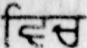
ਵਿਚ
